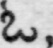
ಓ,
